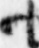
ન
